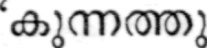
‘കുന്നത്തു
